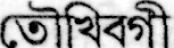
তৌখিবগী
